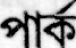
পার্ক
